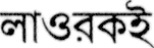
লাওরকই
